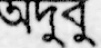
অদুবু
